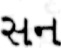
સન
